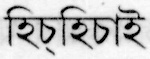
হিচ্‌হিচাই
